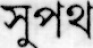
সুপথ
